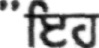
''ਇਹ
